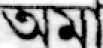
অমা
